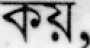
কয়,
